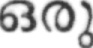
ഒരു
